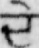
ਦੇ
